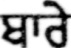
ਬਾਰੇ
